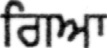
ਗਿਆ
